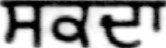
ਸਕਦਾ
